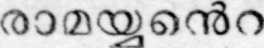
രാമയ്യന്റെ
